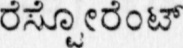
ರೆಸ್ಟೋರೆಂಟ್
